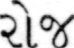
રોજ
